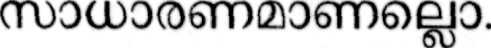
സാധാരണമാണല്ലൊ.
